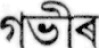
গভীৰ
